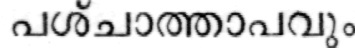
പശ്ചാത്താപവും
